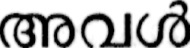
അവള്‍
